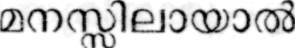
മനസ്സിലായാല്‍
